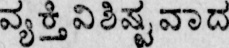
ವ್ಯಕ್ತಿವಿಶಿಷ್ಟವಾದ
